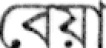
বেয়া
